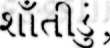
શાઁતીડું,
